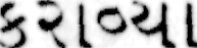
કરાવ્યા
